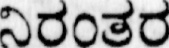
ನಿರಂತರ
